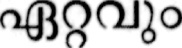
ഏറ്റവും
